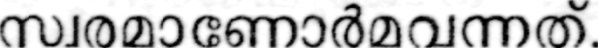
സ്വരമാണോര്‍മവന്നത്.
